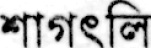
শাগৎলি
